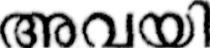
അവയി
